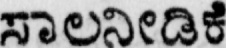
ಸಾಲನೀಡಿಕೆ
